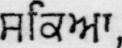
ਸਕਿਆ,
